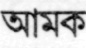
আমক
